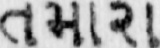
તમારા
